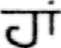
ਹਾਂ
